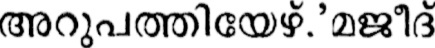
അറുപത്തിയേഴ്.’മജീദ്
